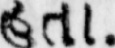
હતા.
